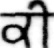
ਕੀ
